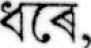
ধৰে,
